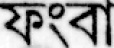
ফংবা
